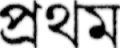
প্রথম
